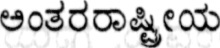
ಅಂತರರಾಷ್ಟ್ರೀಯ
